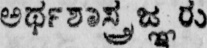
ಅರ್ಥಶಾಸ್ತ್ರಜ್ಞರು
